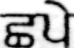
ਛਪੇ
